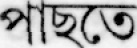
পাছতে
